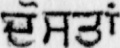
ਦੋਸਤਾਂ
